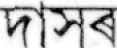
দাসৰ
